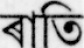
ৰাতি
